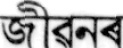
জীৱনৰ
